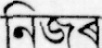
নিজৰ
